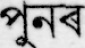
পুনৰ
